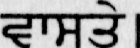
ਵਾਸਤੇ।
